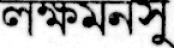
লক্ষমনসু
